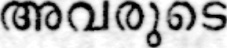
അവരുടെ
